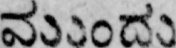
ಮುಂದು
